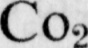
Co2
